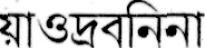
য়াওদ্রবনিনা
